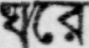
ঘরে
